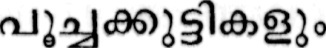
പൂച്ചക്കുട്ടികളും
